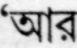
‘আর
